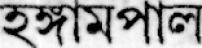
হংঙ্গামপাল
